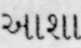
આશા
